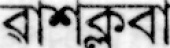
ৱাশক্লবা
